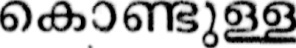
കൊണ്ടുള്ള
